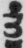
ਤੂੰ
